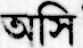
অসি
